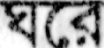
ঘরে
